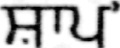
ਸ਼ਾਪ'
